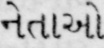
નેતાઓ
